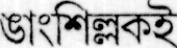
ঙাংশিল্লকই
